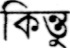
কিন্তু
